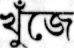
খুঁজে
